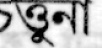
চত্তুনা
